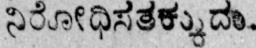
ನಿರೋಧಿಸತಕ್ಕುದು.
